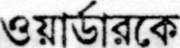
ওয়ার্ডারকে
